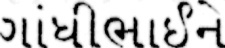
ગાંધીભાઈને
